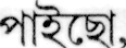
পাইছো,
